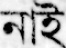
নাই
